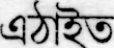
এঠাইত
